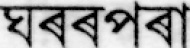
ঘৰৰপৰা
